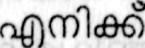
എനിക്ക്
